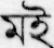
মই
